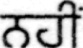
ਨਹੀਂ
